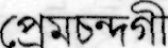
প্রেমচন্দগী
